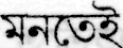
মনতেই
